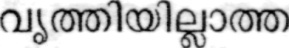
വൃത്തിയില്ലാത്ത
